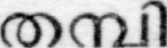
തമ്പി
